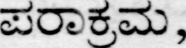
ಪರಾಕ್ರಮ,
